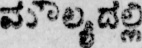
ಮೌಲ್ಯದಲ್ಲಿ
